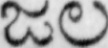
ಜಲ
